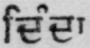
ਦਿੰਦਾ
